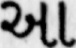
આ
